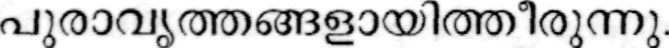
പുരാവൃത്തങ്ങളായിത്തീരുന്നു.
